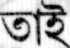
তাই
